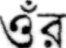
ওঁর
